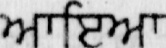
ਆਇਆ
